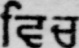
ਵਿਚ
